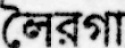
লৈরগা
